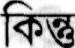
কিন্তু
